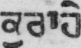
ਕੁਰਾਹੇ
